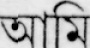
আমি
